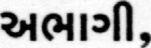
અભાગી,
